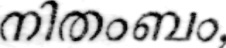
നിതംബം,
